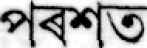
পৰশত
